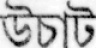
উচাট
